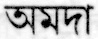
অমদা
